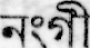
নংগী
